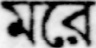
মরে
